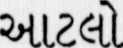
આટલો
